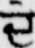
ਦੇ
